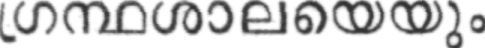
ഗ്രന്ഥശാലയെയും
